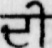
ਦੀ
